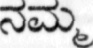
ನಮ್ಮ
